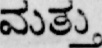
ಮತ್ತು
